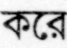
করে
